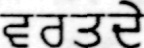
ਵਰਤਦੇ
